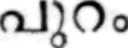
പുറം
